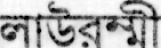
লাউরম্মী
